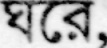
ঘরে,
